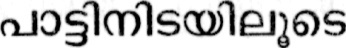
പാട്ടിനിടയിലൂടെ
